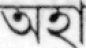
অহা
